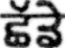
ਛੱਡੇ
